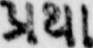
પ્રથા
